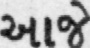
આજે
